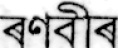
ৰণবীৰ
